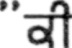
''ਕੀ
